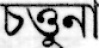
চত্তুনা
